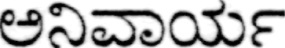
ಅನಿವಾರ್ಯ
